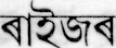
ৰাইজৰ
